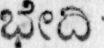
ಭೇದಿ
